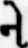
ને
